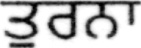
ਤੁਰਨਾ
